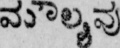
ಮೌಲ್ಯವು
